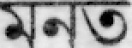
মনত
